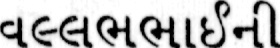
વલ્લભભાઈની
